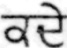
ਕਦੇ
